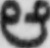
ಆ
